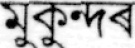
মুকুন্দৰ
